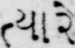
ત્યારે
